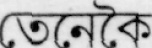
তেনেকৈ
